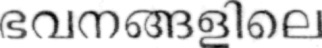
ഭവനങ്ങളിലെ
